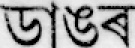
ডাঙৰ
